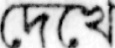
দেখে
